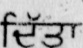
ਦਿੱਤਾ
